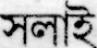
সলাই
